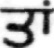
ਤਾਂ
